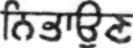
ਨਿਭਾਉਣ
